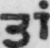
ਤਾਂ
